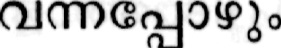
വന്നപ്പോഴും
